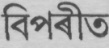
বিপৰীত
